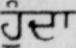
ਹੁੰਦਾ
